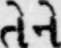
તેને
